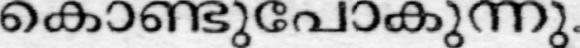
കൊണ്ടുപോകുന്നു.
